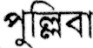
পুল্লিবা
